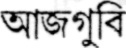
আজগুবি
